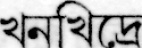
খনখিদ্রে
